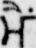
ਮੈਂ
